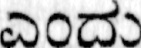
ಎಂದು
